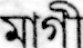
মাগী
